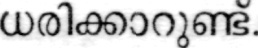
ധരിക്കാറുണ്ട്.
